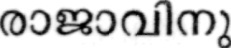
രാജാവിനു
